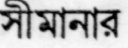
সীমানার
